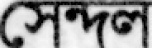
সেন্দল
